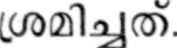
ശ്രമിച്ചത്.
